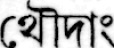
থৌদাং
